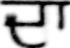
ਦਾ
